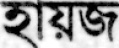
হায়জ
